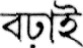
বঢ়াই
